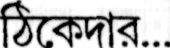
ঠিকেদার...
